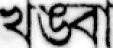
খঙবা
